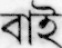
বাই
